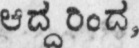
ಆದ್ದರಿಂದ,
